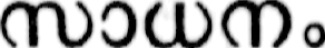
സാധനം
